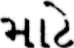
માટે
